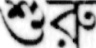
শুরু
